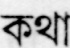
কথা
